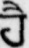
ਹੈ
